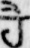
ਹੈ
